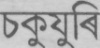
চকুযুৰি
